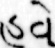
હવે
